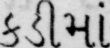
કડીમાં
